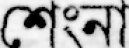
শেংনা
